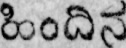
ಹಿಂದಿನ
